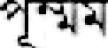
পূম্মম
